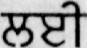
ਲਈ
